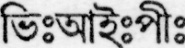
ভিঃআইঃপীঃ
